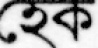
হেক
